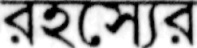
রহস্যের
